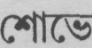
শোভে
